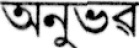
অনুভৱ
